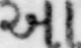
આ
